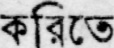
করিতে
